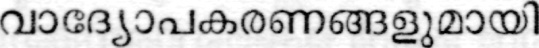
വാദ്യോപകരണങ്ങളുമായി
